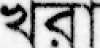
খরা
